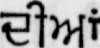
ਦੀਆਂ
